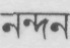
নন্দন
